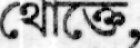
তোক্তে,
